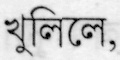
খুলিলে,
